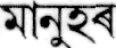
মানুহৰ
